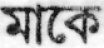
মাকে
